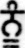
ਨੂੰ
